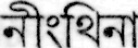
নীংথিনা
